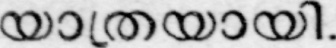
യാത്രയായി.
